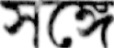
সঙ্গে
